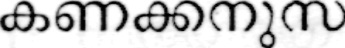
കണക്കനുസ
